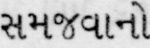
સમજવાનો
